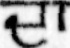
ਦਾ
